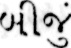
બીજું
